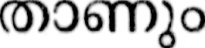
താണും
